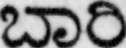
ಬಾರಿ
